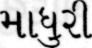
માધુરી
